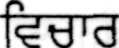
ਵਿਚਾਰ
